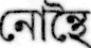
নোন্থৈ
